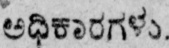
ಅಧಿಕಾರಗಳು.
